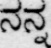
ನನ್ನ
